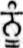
ਨੂੰ
